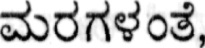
ಮರಗಳಂತೆ,
